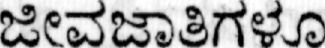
ಜೀವಜಾತಿಗಳೂ
